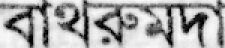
বাথরুমদা
